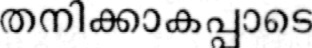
തനിക്കാകപ്പാടെ
